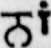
ਨਾਂ
